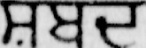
ਸ਼ਬਦ
